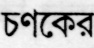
চণকের
